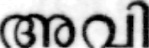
അവി
